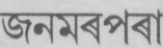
জনমৰপৰা
